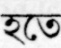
হতে
